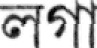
লগা
